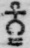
ਨੂੰ
